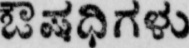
ಔಷಧಿಗಳು
